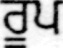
ਰੂਪ
